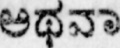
ಅಥವಾ
